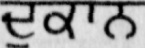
ਦੁਕਾਨ
